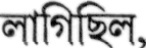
লাগিছিল,
